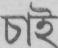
চাই
